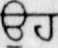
ਉਹ
